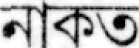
নাকত
